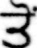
ਤੋਂ
